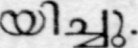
യിച്ചു.
